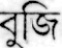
বুজি
